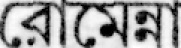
রোমেন্না
